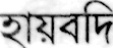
হায়বদি
